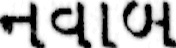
નવાબ
